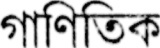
গাণিতিক
